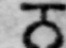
ਨ
